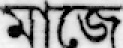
মাজে
